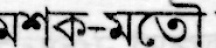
মশক-মতৌ
